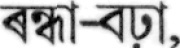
ৰন্ধা-বঢ়া,
